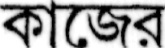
কাজের
